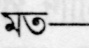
মত–
